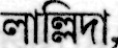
লাল্লিদা,
